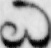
ಎ
